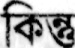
কিন্তু
